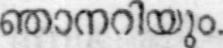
ഞാനറിയും.
